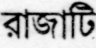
রাজাটি
